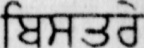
ਬਿਸਤਰੇ
